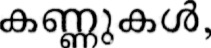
കണ്ണുകള്‍,
